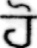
ਹੋ
